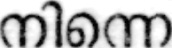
നിന്നെ
